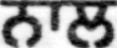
ਨਾਲ
